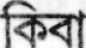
কিবা
